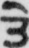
ਤੇ
